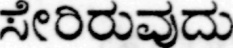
ಸೇರಿರುವುದು
